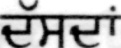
ਦੱਸਦਾਂ
